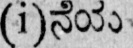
(i)ನೆಯ
